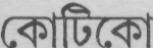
কোটিকো
